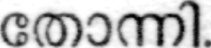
തോന്നി.
